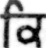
ਕਿ
